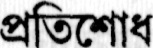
প্রতিশোধ
